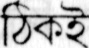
ঠিকই
